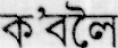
ক'বলৈ
